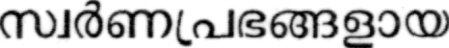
സ്വര്‍ണപ്രഭങ്ങളായ
